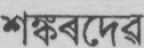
শঙ্কৰদেৱ
